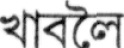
খাবলৈ
